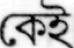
কেই
